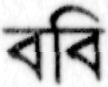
ববি
